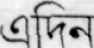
এদিন
